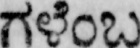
ಗಳೆಂಬ
